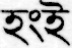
হংই
